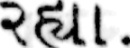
રહ્યા.
